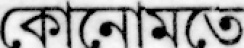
কোনোমতে
